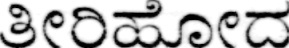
ತೀರಿಹೋದ
